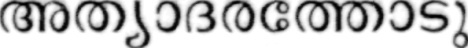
അത്യാദരത്തോടു
